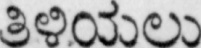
ತಿಳಿಯಲು
